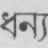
ধন্য
